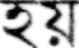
হয়
